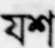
যশ
